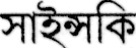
সাইন্সকি
